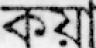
কয়া
